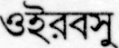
ওইরবসু
